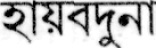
হায়বদুনা
